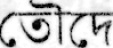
তৌদে
